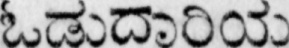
ಓಡುದಾರಿಯ
